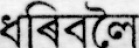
ধৰিবলৈ
